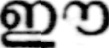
ഈ
